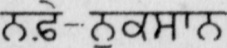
ਨਫ਼ੇ-ਨੁਕਸਾਨ
